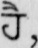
ਹੈ,
